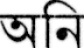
অনি
